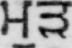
ਮੁੜ
